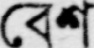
বেশ
